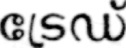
ട്രേഡ്
